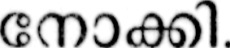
നോക്കി.
